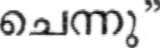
ചെന്നു”
